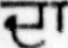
ਦਾ
